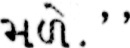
મળે."
